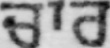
ਚਾਰ
